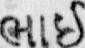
ભાઈ
